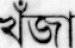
খঁজা
